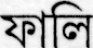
ফালি
